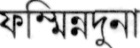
ফম্মিন্নদুনা
